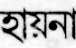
হায়না
